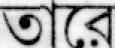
তারে
